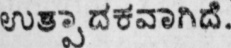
ಉತ್ಪಾದಕವಾಗಿದೆ.
